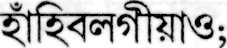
হাঁহিবলগীয়াও;
